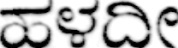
ಹಳದೀ
